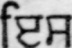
ਇਸ
